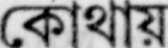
কোথায়
